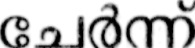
ചേര്‍ന്ന്
